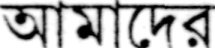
আমাদের
